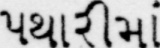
પથારીમાં
